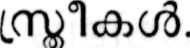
സ്ത്രീകള്‍.
